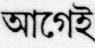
আগেই
